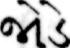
જોડે
